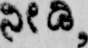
ನೀಡಿ,
